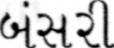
બંસરી
